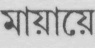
মায়ায়ে
